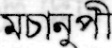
মচানুপী
